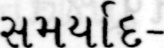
સમર્યાદ-
